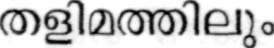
തളിമത്തിലും
